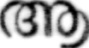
ആ
